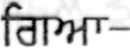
ਗਿਆ-
